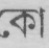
কো
